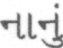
નાનું
